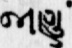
જાણું
